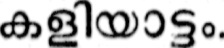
കളിയാട്ടം.
